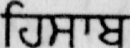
ਹਿਸਾਬ
